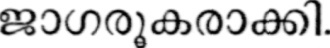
ജാഗരൂകരാക്കി.
